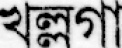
খল্লগা
